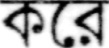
করে
